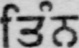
ਤਿੰਨ
